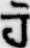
ਹੋ
